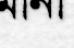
মানা
